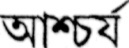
আশ্চর্য
